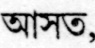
আসত,
